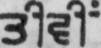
ਤੀਵੀਂ
